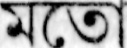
মতো
